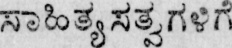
ಸಾಹಿತ್ಯಸತ್ವಗಳಿಗೆ
